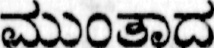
ಮುಂತಾದ
